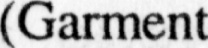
(Garment
